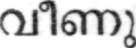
വീണു
